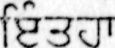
ਇੰਤਹਾ
